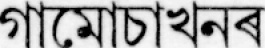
গামোচাখনৰ
